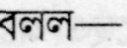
বলল–
